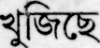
খুজিছে
